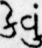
કેવું
